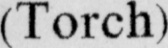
(Torch)
